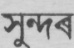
সুন্দৰ
